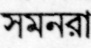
সমনরা
